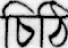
চিঠি
